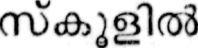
സ്കൂളില്‍
